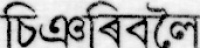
চিঞৰিবলৈ
